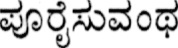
ಪೂರೈಸುವಂಥ
